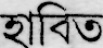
হাবিত
